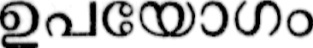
ഉപയോഗം
